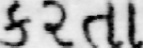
કરતા
